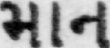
માન
